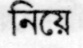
নিয়ে
